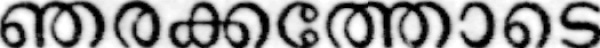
ഞരക്കത്തോടെ
